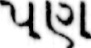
પણ
